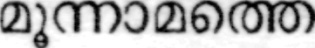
മൂന്നാമത്തെ
